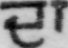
ਦਾ
